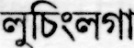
লুচিংলগা
